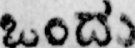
ಒಂದು
